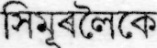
সিমূৰলৈকে
